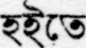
হইতে
